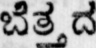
ಬೆತ್ತದ
